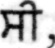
ਸੀ,
